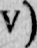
v)
